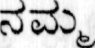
ನಮ್ಮ
